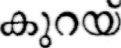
കുറയ്
